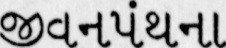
જીવનપંથના
